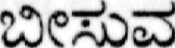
ಬೀಸುವ
